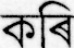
কৰি
